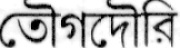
তৌগদৌরি
